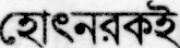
হোৎনরকই
